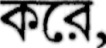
করে,
